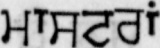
ਮਾਸਟਰਾਂ
